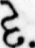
દે.
